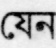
যেন
